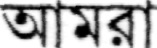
আমরা
